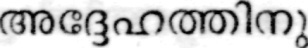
അദ്ദേഹത്തിനു
